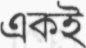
একই
